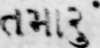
તમારું
